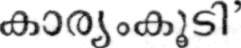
കാര്യംകൂടി'
